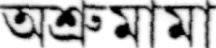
অশ্রুমামা
